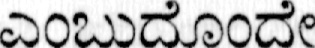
ಎಂಬುದೊಂದೇ
